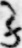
કે
